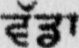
ਵੱਡਾ
